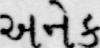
અનેક
